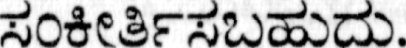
ಸಂಕೀರ್ತಿಸಬಹುದು.
